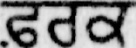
ਫ਼ਰਕ
